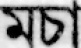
মচা
